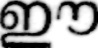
ഈ
